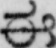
ಈ
